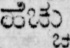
ಹೆಚ್ಚು
